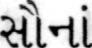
સૌનાં
